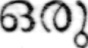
ഒരു
